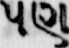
પણ
